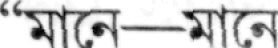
"মানে-মানে
